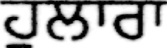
ਹੁਲਾਰਾ
